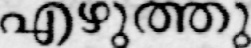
എഴുത്തു
